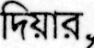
দিয়ার,
